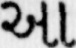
આ
